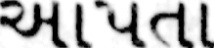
આપતા
